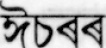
ঈচৰৰ
